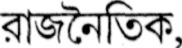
রাজনৈতিক,
